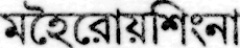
মহৈরোয়শিংনা
